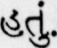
હતું.
